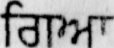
ਗਿਆ
